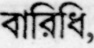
বারিধি,
